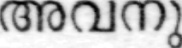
അവനു
